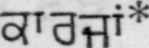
ਕਾਰਜਾਂ*
